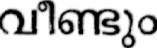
വീണ്ടും
